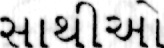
સાથીઓ
